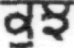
ਕੁਝ
